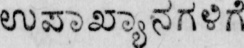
ಉಪಾಖ್ಯಾನಗಳಿಗೆ
